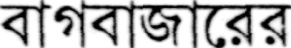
বাগবাজারের
